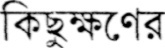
কিছুক্ষণের
